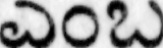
ಎಂಬ
